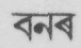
বনৰ
